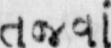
તજવાં
